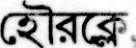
হৌরক্লে
